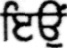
ਇਉਂ
